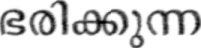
ഭരിക്കുന്ന
